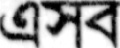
এসব
